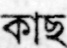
কাছ
